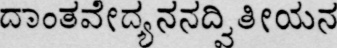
ದಾಂತವೇದ್ಯನನದ್ವಿತೀಯನ
